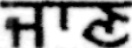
ਜਾਣ
